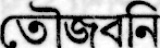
তৌজবনি
